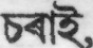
চৰাই,
